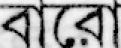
বারো
